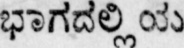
ಭಾಗದಲ್ಲಿಯ
